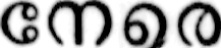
നേരെ
